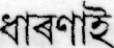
ধাৰণাই
